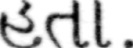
હતા.
